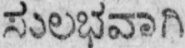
ಸುಲಭವಾಗಿ
